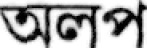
অলপ
